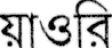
য়াওরি
